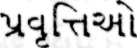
પ્રવૃત્તિઓ
